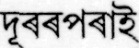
দূৰৰপৰাই
